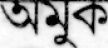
অমুক
